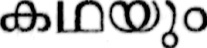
കഥയും
